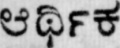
ಆರ್ಥಿಕ
